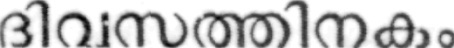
ദിവസത്തിനകം
